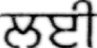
ਲਈ
